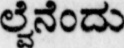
ಲ್ವೆನೆಂದು
